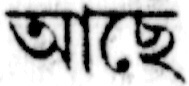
আছে
